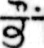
ਭੌਂ
